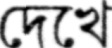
দেখে
